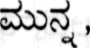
ಮುನ್ನ,
